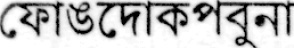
ফোঙদোকপবুনা
